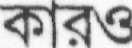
কারও
